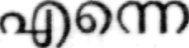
എന്നെ
